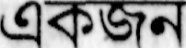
একজন
